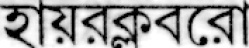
হায়রক্লবরো
